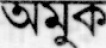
অমুক
